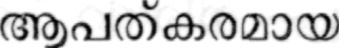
ആപത്കരമായ
